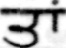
ਤਾਂ
